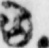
છે.
